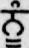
ਨੂੰ
